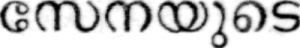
സേനയുടെ
